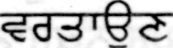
ਵਰਤਾਉਣ
